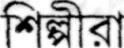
শিল্পীরা
